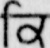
ਕਿ
